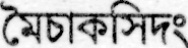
মৈচাকসিদং
